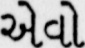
એવો
